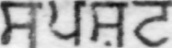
ਸਪਸ਼ਟ
